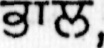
ਭਾਲ,
